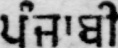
ਪੰਜਾਬੀ
